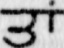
ਤਾਂ
